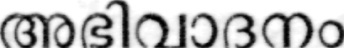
അഭിവാദനം
